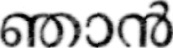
ഞാന്‍
